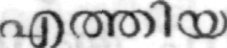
എത്തിയ
